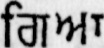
ਗਿਆ
